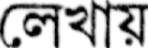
লেখায়
